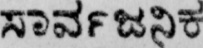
ಸಾರ್ವಜನಿಕ
